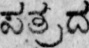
ಪತ್ರದ
